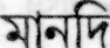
মানদি
